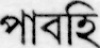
পাবহি
